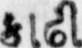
કાઢી
